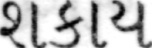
શકાય
